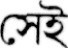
সেই
